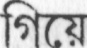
গিয়ে
